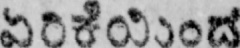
ಏರಿಕೆಯಿಂದ
